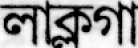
লাক্লগা
